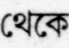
থেকে
